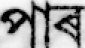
পাৰ
